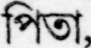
পিতা,
